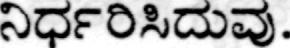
ನಿರ್ಧರಿಸಿದುವು.
